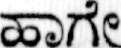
ಹಾಗೇ
